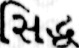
સિદ્ધ
